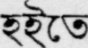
হইতে
